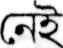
নেই
